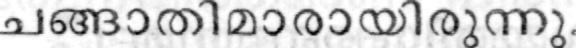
ചങ്ങാതിമാരായിരുന്നു.
